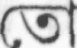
তো
